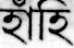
হাঁহি
